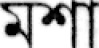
মশা
